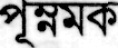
পূম্নমক
